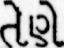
તેણે
